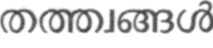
തത്ത്വങ്ങള്‍
